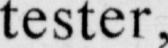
tester,
